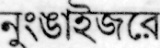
নুংঙাইজরে
